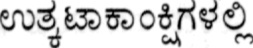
ಉತ್ಕಟಾಕಾಂಕ್ಷಿಗಳಲ್ಲಿ
